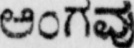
ಅಂಗವು
